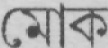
মোক
